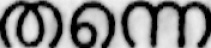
തന്നെ
